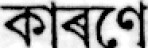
কাৰণে
